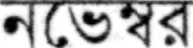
নভেম্বর
